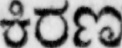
ಕಿರಣ
